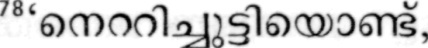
78നെററിച്ചുട്ടിയൊണ്ട്,
